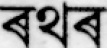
ৰথৰ
